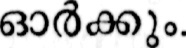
ഓര്‍ക്കും.
